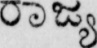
ರಾಜ್ಯ
